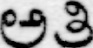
ಅತಿ
